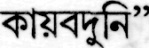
কায়বদুনি”
